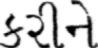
કરીને
